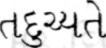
તદુચ્યતે
